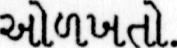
ઓળખતો.
